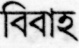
বিবাহ
